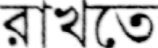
রাখতে
